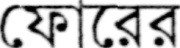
ফোরের
